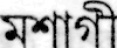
মশাগী
